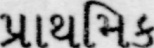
પ્રાથમિક
